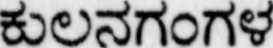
ಕುಲನಗಂಗಳ
